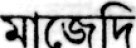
মাজেদি
